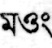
মওং
